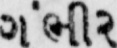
ગંભીર
